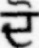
ਦੋ
